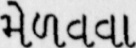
મેળવવા
